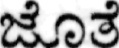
ಜೊತೆ
